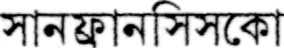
সানফ্রানসিসকো
